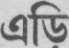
এড়ি
